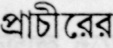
প্রাচীরের
